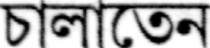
চালাতেন
